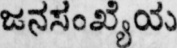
ಜನಸಂಖ್ಯೆಯ
